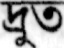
দ্রুত
